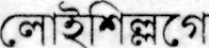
লোইশিল্লগে
